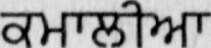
ਕਮਾਲੀਆ
